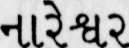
નારેશ્વર
